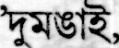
’দুমঙাই,
